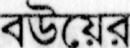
বউয়ের
